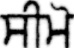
ਸੀਮੋ
